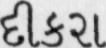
દીકરા
